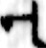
ન
